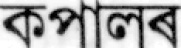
কপালৰ
